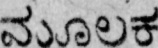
ಮೂಲಕ
